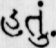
હતું.
